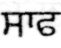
ਸਾਫ
